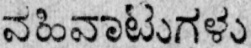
ವಹಿವಾಟುಗಳು
